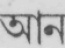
আন
